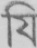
যি
